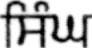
ਸਿੰਘ
